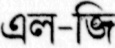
এল-জি
